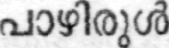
പാഴിരുള്‍
